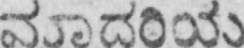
ಮಾದರಿಯ
